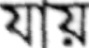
যায়
